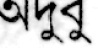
অদুবু
